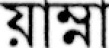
য়াম্না
